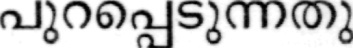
പുറപ്പെടുന്നതു
